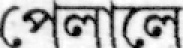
পেলালে
